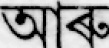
আৰু
